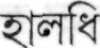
হালধি
